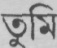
তুমি
